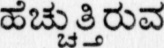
ಹೆಚ್ಚುತ್ತಿರುವ
